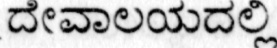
ದೇವಾಲಯದಲ್ಲಿ
